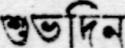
শুভদিন
